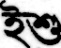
ইশু
